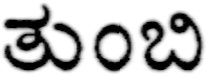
ತುಂಬಿ
